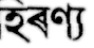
হিৰণ্য
